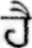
ਹੈ
